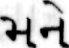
મને
